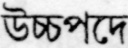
উচ্চপদে
